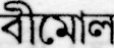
বীমোল
